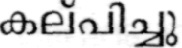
കല്പിച്ചു
